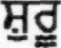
ਸ਼ੁਰੂ
